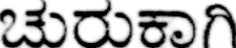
ಚುರುಕಾಗಿ
